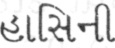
હાસિની
